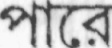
পারে
